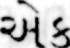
એક
